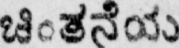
ಚಿಂತನೆಯ
